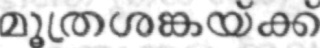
മൂത്രശങ്കയ്ക്ക്
